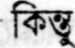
কিন্তু
